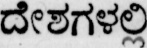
ದೇಶಗಳಲ್ಲಿ
